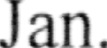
Jan.
